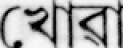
খোৱা
